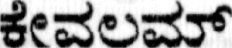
ಕೇವಲಮ್
